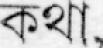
কথা,
